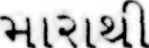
મારાથી
